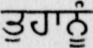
ਤੁਹਾਨੂੰ
